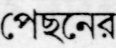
পেছনের
